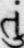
તું
